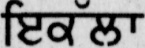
ਇਕੱਲਾ
